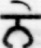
ਨੇ
